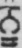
ਨੂੰ
